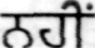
ਨਹੀਂ
